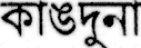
কাঙদুনা
